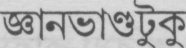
জ্ঞানভাণ্ডটুকু
